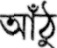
আঁঠু
